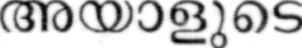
അയാളുടെ
